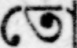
তো
